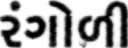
રંગોળી
